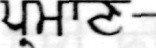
ਪ੍ਰਮਾਣ-
